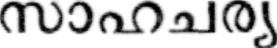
സാഹചര്യ
